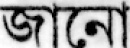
জানো
